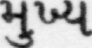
મુખ્ય
